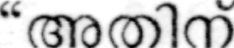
“അതിന്
